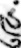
હું
